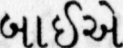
બાઈએ
